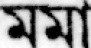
মমা
